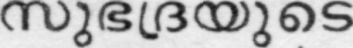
സുഭദ്രയുടെ
